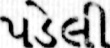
પડેલી
